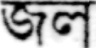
জল
